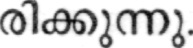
രിക്കുന്നു.
